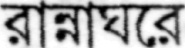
রান্নাঘরে
